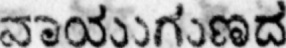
ವಾಯುಗುಣದ
